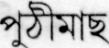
পুঠীমাছ
